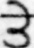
ਤੇ
